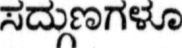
ಸದ್ಗುಣಗಳೂ
